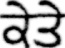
ਕੇਤੇ
